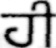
ਹੀ
